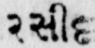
રસીદ
